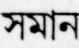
সমান
